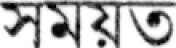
সময়ত
